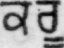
ਕਰੂ
